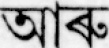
আৰু
